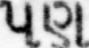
પણ
